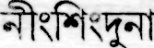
নীংশিংদুনা
